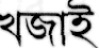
খজাই
